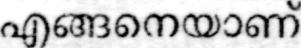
എങ്ങനെയാണ്
